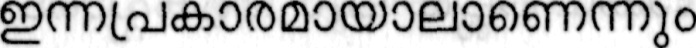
ഇന്നപ്രകാരമായാലാണെന്നും
